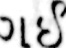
ગઈ
